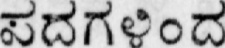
ಪದಗಳಿಂದ
